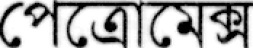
পেত্রোমেক্স
